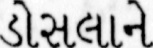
ડોસલાને
